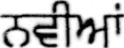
ਨਵੀਆਂ
